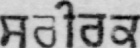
ਸਰੀਰਕ
